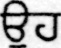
ਉਹ
